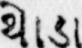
થોડા
